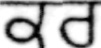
ਕਰ
